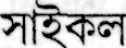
সাইকল
